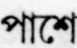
পাশে
